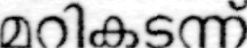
മറികടന്ന്
